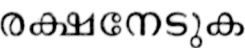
രക്ഷനേടുക
